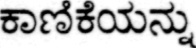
ಕಾಣಿಕೆಯನ್ನು
